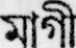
মাগী
